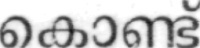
കൊണ്ട്
